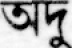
অদু
